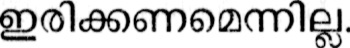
ഇരിക്കണമെന്നില്ല.
